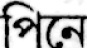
পিনে
